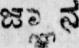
ಜ್ಞಾನ
